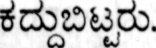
ಕದ್ದುಬಿಟ್ಟರು.
